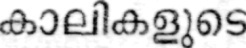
കാലികളുടെ
